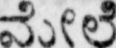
ಮೇಲೆ
